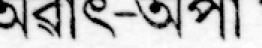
অৱাৎ-অপা
